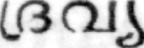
ദ്രവ്യ
